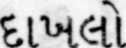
દાખલો
